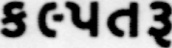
કલ્પતરૂ
